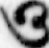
ও
